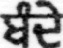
ਬੰਦੇ
